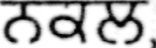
ਨਕਲ,
